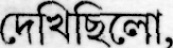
দেখিছিলো,
